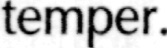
temper.
